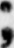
છીએ;
